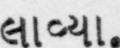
લાવ્યા.
